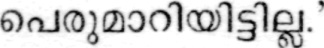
പെരുമാറിയിട്ടില്ല.’
